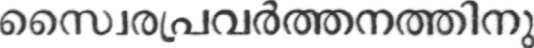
സ്വൈരപ്രവര്‍ത്തനത്തിനു
